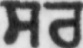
ਸਰ
